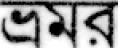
ভ্রমর
